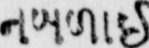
નબળાઈ
